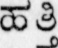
ಹತ್ತಿ
